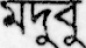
মদুবু
